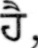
ਹੈ,
